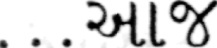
...આજ
